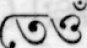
তেওঁ
